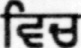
ਵਿਚ
